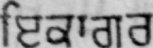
ਇਕਾਗਰ
